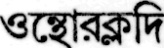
ওন্থোরক্লদি
